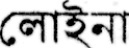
লোইনা
